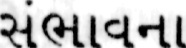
સંભાવના
